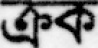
ক্রক
